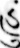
હું
